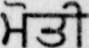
ਮੋਤੀ
